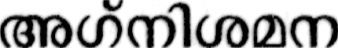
അഗ്നിശമന
